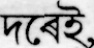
দৰেই,
